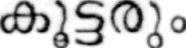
കൂട്ടരും
